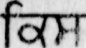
ਕਿਸ
